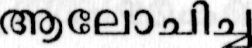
ആലോചിച്ച
